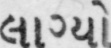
લાગ્યો
